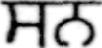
ਸਨ
